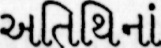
અતિથિનાં
